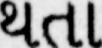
થતા
